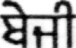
ਬੇਜੀ
